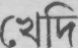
খেদি
